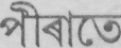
পীৰাতে
